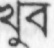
খুব
